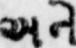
અને
